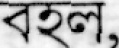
বহল,
